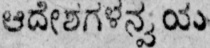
ಆದೇಶಗಳನ್ವಯ
